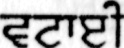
ਵਟਾਈ
